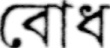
বোধ
